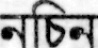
নচিন
